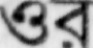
ওর
